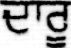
ਦਾਰੂ
